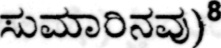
ಸುಮಾರಿನವು)8
